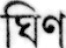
ঘিণ
